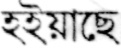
হইয়াছে
